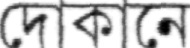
দোকানে
